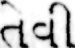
તેવી
